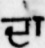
ਦਾ
